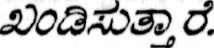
ಖಂಡಿಸುತ್ತಾರೆ.
